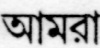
আমরা
